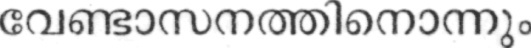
വേണ്ടാസനത്തിനൊന്നും
